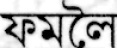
ফমলৈ
